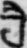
ਹੈ
